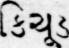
કિચૂડ
